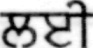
ਲਈ
